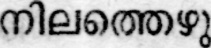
നിലത്തെഴു
